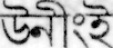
উনীংই
